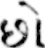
છો
